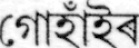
গোহাঁইৰ
